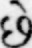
છે
